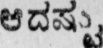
ಆದಷ್ಟು
